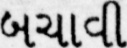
બચાવી
